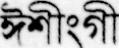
ঈশীংগী
